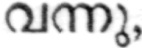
വന്നു,
